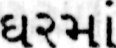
ઘરમાં
